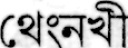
থেংনখী
